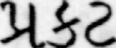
પ્રકટ
